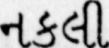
નકલી
